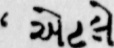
'એટલે
